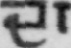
ਦਾ
